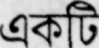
একটি
